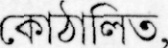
কোঠালিত,
